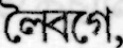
লৈবগে,
